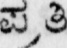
ಪ್ರತಿ
